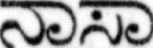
ನಾಸಾ
